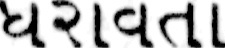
ધરાવતા
